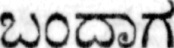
ಬಂದಾಗ
